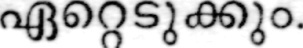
ഏറ്റെടുക്കും.
